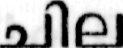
ചില
